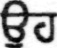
ਉਹ
